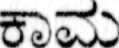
ಕಾಮ
